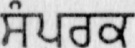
ਸੰਪਰਕ
